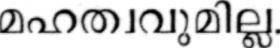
മഹത്വവുമില്ല.
